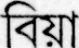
বিয়া
